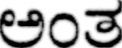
ಅಂತ
